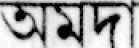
অমদা
